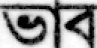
ভাব
